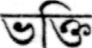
ভক্তি
